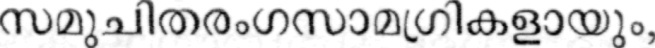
സമുചിതരംഗസാമഗ്രികളായും,
